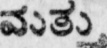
ಮತ್ತು
